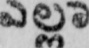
ಎಲ್ಲಾ
